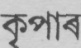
কৃপাৰ
